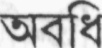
অবধি
